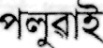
পলুৱাই
